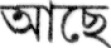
আছে
